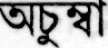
অচুম্বা
